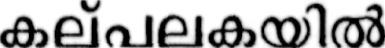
കല്പലകയില്‍
